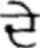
ਦੇ
